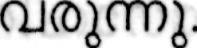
വരുന്നു.
